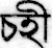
চহী
